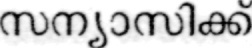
സന്യാസിക്ക്
